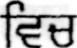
ਵਿਚ
